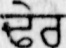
ਢੇਰ
